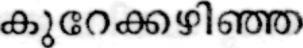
കുറേക്കഴിഞ്ഞ
